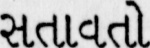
સતાવતો
